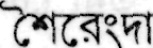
শৈরেংদা
